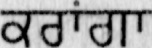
ਕਰਾਂਗਾ
